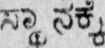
ಸ್ಥಾನಕ್ಕೆ
